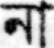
না
